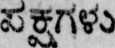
ಪಕ್ಷಗಳು
